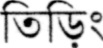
তিড়িং
